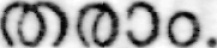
തരാം.
